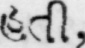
હતી,
